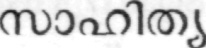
സാഹിത്യ
